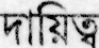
দায়িত্ব
